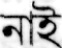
নাই
